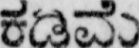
ಕಡಿಮೆ
